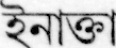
ইনাক্তা
